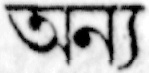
অন্য
